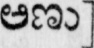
ಅಣು]
